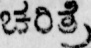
ಚರಿತ್ರೆ
